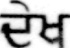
ਦੇਖ
